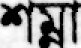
শম্না
